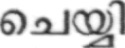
ചെയ്യി
